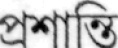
প্রশান্তি
